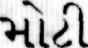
મોટી
